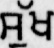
ਸੁੱਖ
